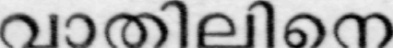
വാതിലിനെ
